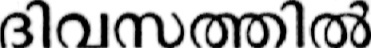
ദിവസത്തില്‍
